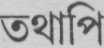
তথাপি
